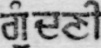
ਗੁੰਦਣੀ
